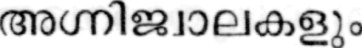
അഗ്നിജ്വാലകളും
